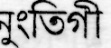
নুংতিগী
